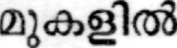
മുകളില്‍
